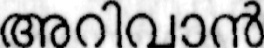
അറിവാന്‍
